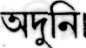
অদুনি।
